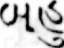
બહુ
